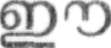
ഈ
